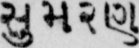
સુમરણ
